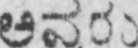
ಅವರು
